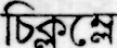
চিক্লম্লে
